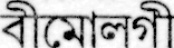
বীমোলগী
